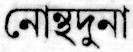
নোন্থদুনা
